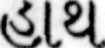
હાથ
